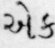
એક
